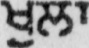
ਖੁਲਾ
